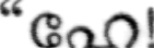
“ഹേ!
